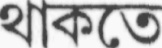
থাকতে
